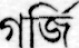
গর্জি
